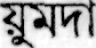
য়ুমদা
